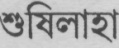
শুষিলাহা
